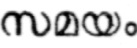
സമയം
